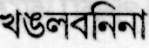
খঙলবনিনা
